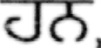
ਹਨ,
